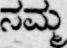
ನಮ್ಮ
